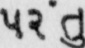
પરંતુ
